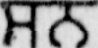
ਸਨ
